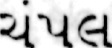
ચંપલ
